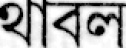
থাবল
